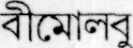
বীমোলবু
